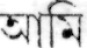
আমি
